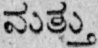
ಮತ್ತು
